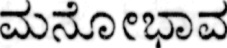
ಮನೋಭಾವ
